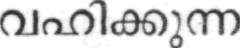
വഹിക്കുന്ന
